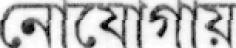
নোযোগায়
